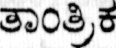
ತಾಂತ್ರಿಕ
